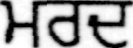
ਮਰਦ
